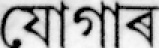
যোগাৰ
